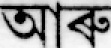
আৰু
